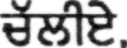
ਚੱਲੀਏ,
